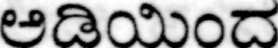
ಅಡಿಯಿಂದ
